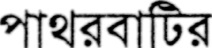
পাথরবাটির
